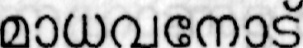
മാധവനോട്
